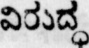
ವಿರುದ್ಧ
